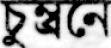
চুম্ব্রনে
